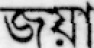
জয়া
